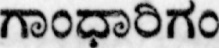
ಗಾಂಧಾರಿಗಂ
